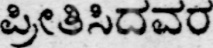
ಪ್ರೀತಿಸಿದವರ
